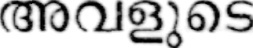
അവളുടെ
